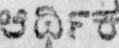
ಆರ್ಥಿಕ
